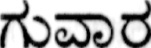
ಗುವಾರ
